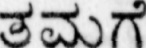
ತಮಗೆ
